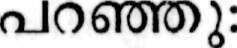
പറഞ്ഞു:
